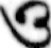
ও
